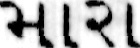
મારા
